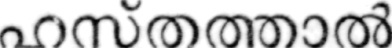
ഹസ്തത്താല്‍
